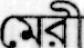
মেরী
